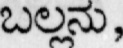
ಬಲ್ಲನು,
